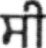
ਸੀ
